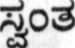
ಸ್ವಂತ
